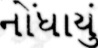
નોંધાયું
